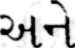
અને
